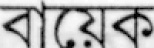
বায়েক
